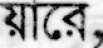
য়ারে,
